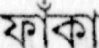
ফাঁকা
